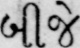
બીજે
